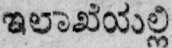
ಇಲಾಖೆಯಲ್ಲಿ
